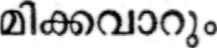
മിക്കവാറും
